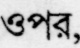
ওপর,
